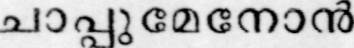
ചാപ്പുമേനോന്‍
